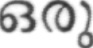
ഒരു
